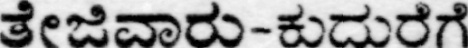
ತೇಜಿವಾರು-ಕುದುರೆಗೆ
